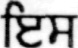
ਇਸ
